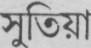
সুতিয়া
